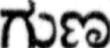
ಗುಣ
